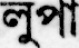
লুপা
